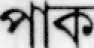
পাক
